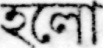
হলো
